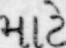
માટે
